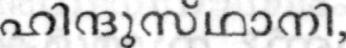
ഹിന്ദുസ്ഥാനി,
